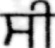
ਸੀ
